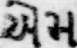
એમ
